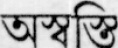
অস্বস্তি
